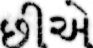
છીએ
